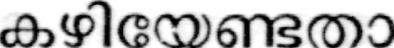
കഴിയേണ്ടതാ
